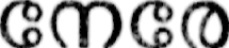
നേരേ
